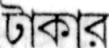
টাকার
